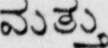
ಮತ್ತು
